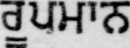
ਰੂਪਮਾਨ
